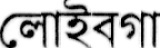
লোইবগা
